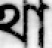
থা
